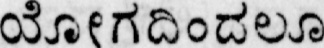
ಯೋಗದಿಂದಲೂ
